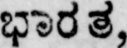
ಭಾರತ,
